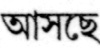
আসছে
